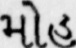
મોહ
